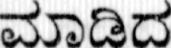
ಮಾಡಿದ
